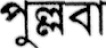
পুল্লবা
